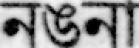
নঙনা
